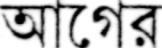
আগের
